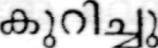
കുറിച്ചു
